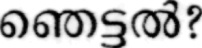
ഞെട്ടല്‍?
